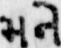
મને
